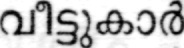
വീട്ടുകാര്‍
